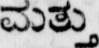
ಮತ್ತು
